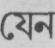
যেন
